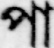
পা
